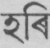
হৰি
